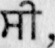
ਸੀ,
